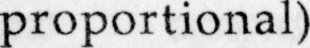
proportional)
